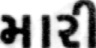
મારી
